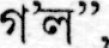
গ'ল",
